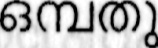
ഒമ്പതു
